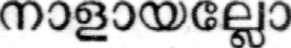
നാളായല്ലോ
